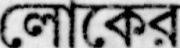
লোকের
